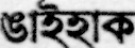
ঙাইহাক
